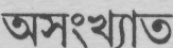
অসংখ্যাত
